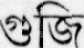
গুজি
